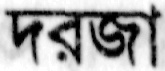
দরজা
